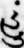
હું
